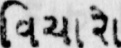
વિચારો
